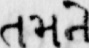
તમને
